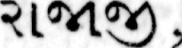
રાજાજી,
